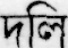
দলি
